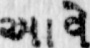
આવે
